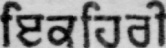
ਇਕਹਿਰੀ
